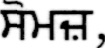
ਸੋਮਜ਼,
